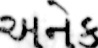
અનેક
